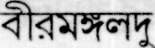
বীরমঙ্গলদু
